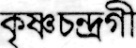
কৃষ্ণচন্দ্রগী
